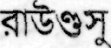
রাউণ্ডসু
